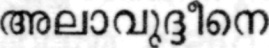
അലാവുദ്ദീനെ
